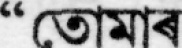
"তোমাৰ
